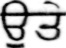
ਉਤੇ
